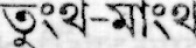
তুংথ-মাংথ
